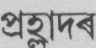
প্ৰহ্লাদৰ
